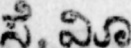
ಸೆ.ಮೀ
